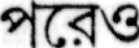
পরেও
